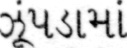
ઝૂંપડામાં
